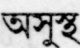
অসুস্থ
